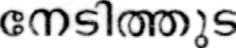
നേടിത്തുട
